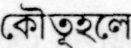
কৌতূহলে
